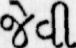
જેવી
